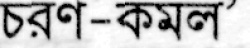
‘চরণ-কমল’
